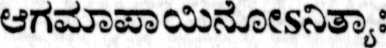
ಆಗಮಾಪಾಯಿನೋsನಿತ್ಯಾಃ
